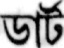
ডার্ট
